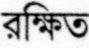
রক্ষিত
